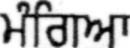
ਮੰਗਿਆ
